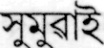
সুমুৱাই
